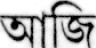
আজি
